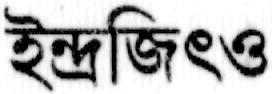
ইন্দ্রজিৎও
